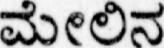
ಮೇಲಿನ
